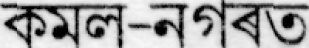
কমল-নগৰত
